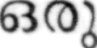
ഒരു
